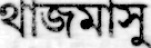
থাজমাসু
